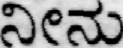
ನೀನು
